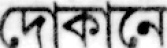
দোকানে
